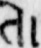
તો
